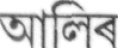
আলিৰ
